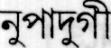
নুপাদুগী
